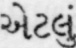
એટલું
